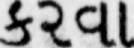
કરવા
